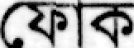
ফোক
